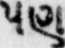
પણ
